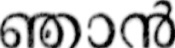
ഞാന്‍
